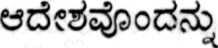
ಆದೇಶವೊಂದನ್ನು
